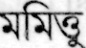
মমিত্তু
